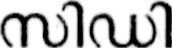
സിഡി
